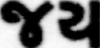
જય
